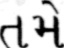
તમે
